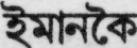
ইমানকৈ
